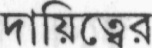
দায়িত্বের
